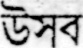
উসব
